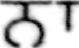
ਨਾ
